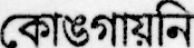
কোঙগায়নি
